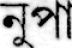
নুপা
